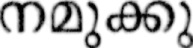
നമുക്കു
